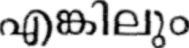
എങ്കിലും
